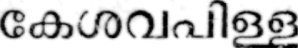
കേശവപിള്ള
